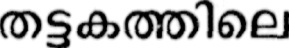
തട്ടകത്തിലെ
